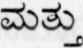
ಮತ್ತು
